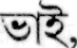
ভাই,
